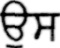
ਉਸ
